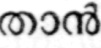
താന്‍
